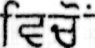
ਵਿਚੋਂ
